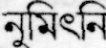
নুমিৎনি
